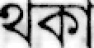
থকা
